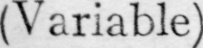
(Variable)
